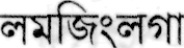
লমজিংলগা
